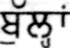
ਬੁੱਲ੍ਹਾਂ
